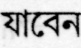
যাবেন
